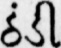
ઠંડી
